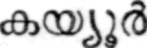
കയ്യൂര്‍
